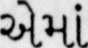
એમાં
